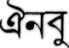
ঐনবু
